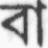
বা
